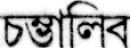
চম্ভালিব
